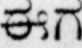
ಈಗ
